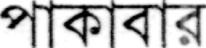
পাকাবার
